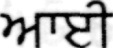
ਆਈ
